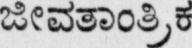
ಜೀವತಾಂತ್ರಿಕ
